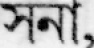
সনা,
